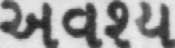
અવશ્ય
